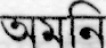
অমনি
